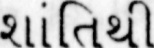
શાંતિથી
